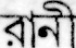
রানী
